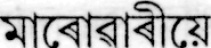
মাৰোৱাৰীয়ে
